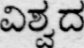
ವಿಶ್ವದ
